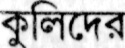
কুলিদের
